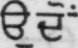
ਉਦੋਂ
